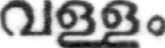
വള്ളം
